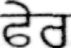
ਫੇਰ
